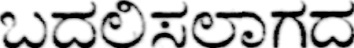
ಬದಲಿಸಲಾಗದ
